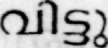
വിട്ടു
